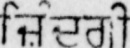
ਜ਼ਿੰਦਗੀ
